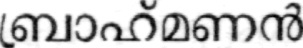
ബ്രാഹ്മണന്‍
